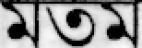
মতম
